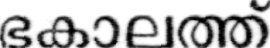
ഭകാലത്ത്
